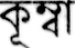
কূম্বা
